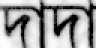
দাদা
